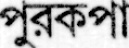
পুরকপা
